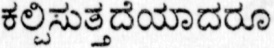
ಕಲ್ಪಿಸುತ್ತದೆಯಾದರೂ
